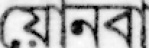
য়োনবা
